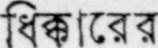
ধিক্কারের
